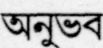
অনুভব
